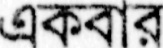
একবার
